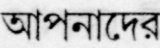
আপনাদের
